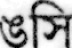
ঙসি
